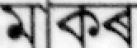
মাকৰ
